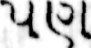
પણ
